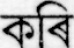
কৰি
